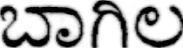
ಬಾಗಿಲ
